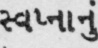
સ્વપ્નાનું
